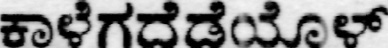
ಕಾಳೆಗದೆಡೆಯೊಳ್
